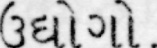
ઉધોગો.
